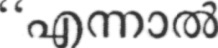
"എന്നാല്‍
